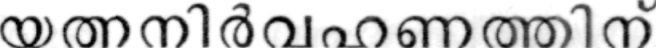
യത്നനിര്‍വഹണത്തിന്
